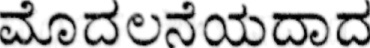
ಮೊದಲನೆಯದಾದ
